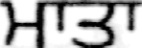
ਮਾਤਾ
